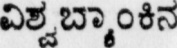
ವಿಶ್ವಬ್ಯಾಂಕಿನ
